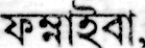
ফম্নাইবা,
